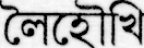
লৈহৌখি
